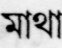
মাথা
